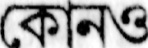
কোনও
